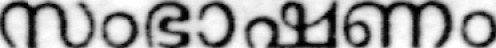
സംഭാഷണം
